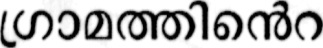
ഗ്രാമത്തിന്റെ
